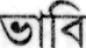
ভাবি
